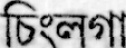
চিংলগা
